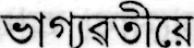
ভাগ্যৱতীয়ে
